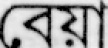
বেয়া
